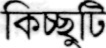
কিচ্ছুটি
